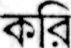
করি
